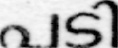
പടി
